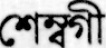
শেম্বগী
